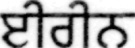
ਈਰੀਨ
